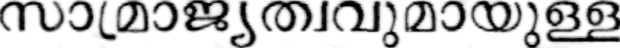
സാമ്രാജ്യത്വവുമായുള്ള
